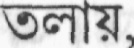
তলায়,
